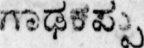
ಗಾಢಕಪ್ಪು
